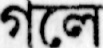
গলে
